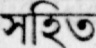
সহিত
